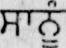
ਸਾਨੂੰ
